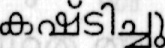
കഷ്ടിച്ചു
